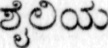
ಶೈಲಿಯ
